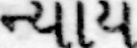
ન્યાય
